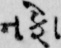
નફો
